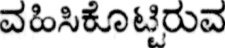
ವಹಿಸಿಕೊಟ್ಟಿರುವ
